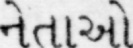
નેતાઓ
